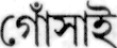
গোঁসাই
